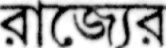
রাজ্যের
